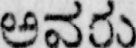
ಅವರು
